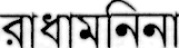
রাধামনিনা
